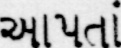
આપતાં
